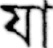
যা
